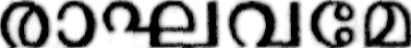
രാഘവമേ
